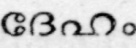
ദേഹം
